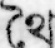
থৈ
